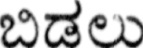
ಬಿಡಲು
